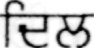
ਦਿਲ
